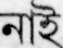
নাই
